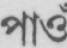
পাওঁ
